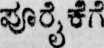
ಪೂರೈಕೆಗೆ
